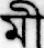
মী
